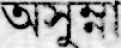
অসুম্না
